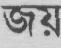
জয়
